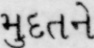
મુદતને
